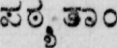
ಪಠ್ಯತಾಂ
